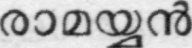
രാമയ്യന്‍
